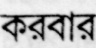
করবার
